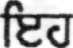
ਇਹ
